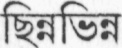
ছিন্নভিন্ন
